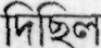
দিছিল
